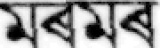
মৰমৰ
